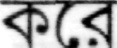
করে
